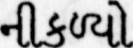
નીકળ્યો
